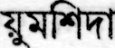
য়ুমশিদা
